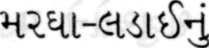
મરઘા-લડાઈનું
